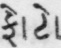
ફોટો
